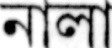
নালা
